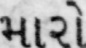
મારો
